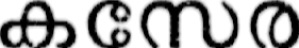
കസേര
